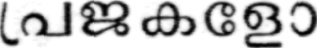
പ്രജകളോ
